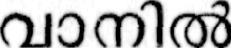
വാനില്‍
